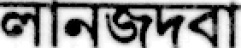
লানজদবা
